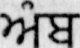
ਅੰਬ
